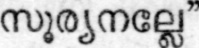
സൂര്യനല്ലേ"
